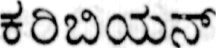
ಕರಿಬಿಯನ್
